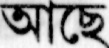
আছে
